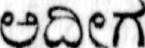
ಅದೀಗ
